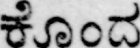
ಕೊಂದ
